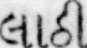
લાઠી
